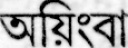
অয়িংবা
